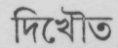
দিখৌত
